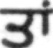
ਤਾਂ
